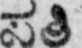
ಪತಿ
